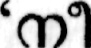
'നീ
